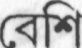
বেশি
